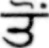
ਤੋਂ
